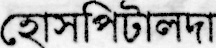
হোসপিটালদা
